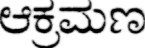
ಆಕ್ರಮಣ
